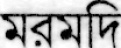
মরমদি
